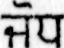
ਜੋਧ
